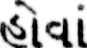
હોવાં
